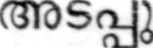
അടപ്പു
